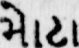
મોટા
